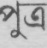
পুত্র
